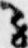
કે
